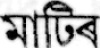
মাটিৰ
